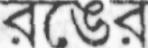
রঙের
